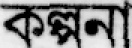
কল্পনা
